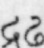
દ્રઢ
